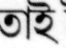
তাই
